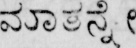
ಮಾತನ್ನೇ
